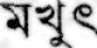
মখুৎ
